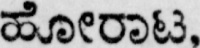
ಹೋರಾಟ,
